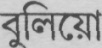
বুলিয়ো
